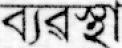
ব্যৱস্হা
